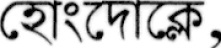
হোংদোক্লে,
